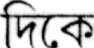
দিকে
